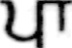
ਪਾ
